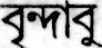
বৃন্দাবু
